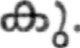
കു.
